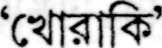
‘খোরাকি’
